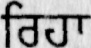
ਰਿਹਾ
